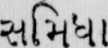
સમિધા
